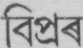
বিপ্ৰৰ
